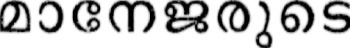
മാനേജരുടെ
